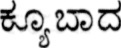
ಕ್ಯೂಬಾದ
